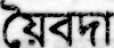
য়ৈবদা
